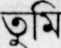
তুমি
